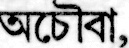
অচৌবা,
